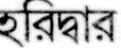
হরিদ্বার
